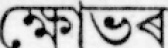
ক্ষোভৰ
